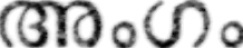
അംഗം
